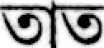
তাত
